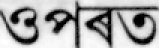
ওপৰত
